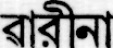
ৱারীনা
